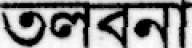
তলবনা
